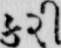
કરી
